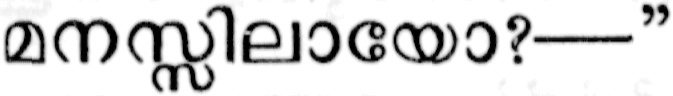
മനസ്സിലായോ?-”
